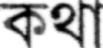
কথা
